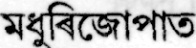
মধুৰিজোপাত
